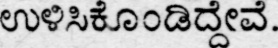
ಉಳಿಸಿಕೊಂಡಿದ್ದೇವೆ.
